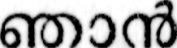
ഞാന്‍
